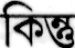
কিন্তু
